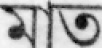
মাত
